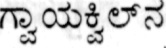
ಗ್ವಾಯಕ್ವಿಲ್ನ
